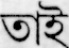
তাই
